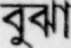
বুঝা
